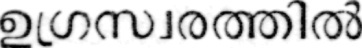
ഉഗ്രസ്വരത്തില്‍
